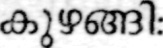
കുഴങ്ങി:
